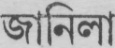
জানিলা
